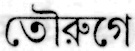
তৌরুগে
